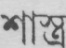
শাস্ত্র
